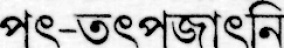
পৎ-তৎপজাৎনি
